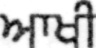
ਆਖੀ
